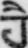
ਹੈ
